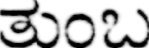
ತುಂಬ
